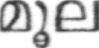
മൂല
